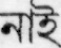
নাই
